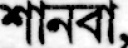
শানবা,
